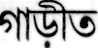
গাড়ীত
